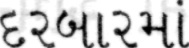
દરબારમાં
